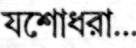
যশোধরা...
